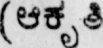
(ಆಕೃತಿ
